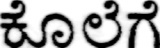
ಕೊಲೆಗೆ
